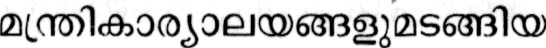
മന്ത്രികാര്യാലയങ്ങളുമടങ്ങിയ
